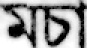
মচা
